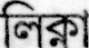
লিক্না
